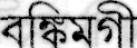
বঙ্কিমগী
